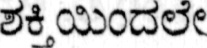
ಶಕ್ತಿಯಿಂದಲೇ
